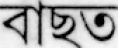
বাছত
